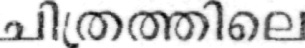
ചിത്രത്തിലെ
